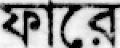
ফারে
